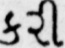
કરી
